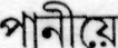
পানীয়ে
